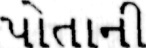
પોતાની
